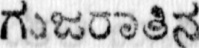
ಗುಜರಾತಿನ
